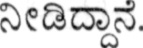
ನೀಡಿದ್ದಾನೆ.
